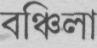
বঞ্চিলা
